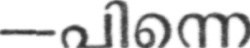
-പിന്നെ
